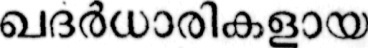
ഖദര്‍ധാരികളായ
